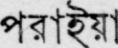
পরাইয়া
